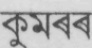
কুমৰৰ
